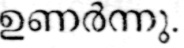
ഉണര്‍ന്നു.
